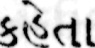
કહેતા
